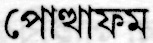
পোত্থাফম
